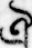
ঐ
